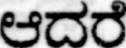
ಆದರೆ
